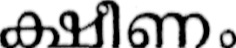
ക്ഷീണം
